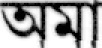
অমা
